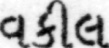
વકીલ
